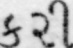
કરી
